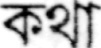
কথা
